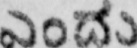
ಎಂದು
